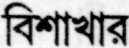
বিশাখার
